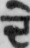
ਦੇ
